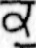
ਕੁ
